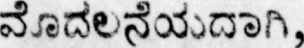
ಮೊದಲನೆಯದಾಗಿ,
